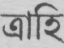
ত্ৰাহি
